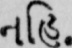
નહિ.
